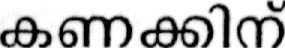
കണക്കിന്
